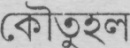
কৌতুহল
